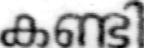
കണ്ടി
